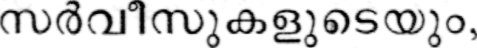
സര്‍വീസുകളുടെയും,
